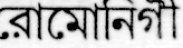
রোমোনিগী
